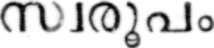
സ്വരൂപം
